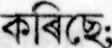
কৰিছে;
